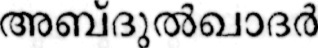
അബ്ദുല്‍ഖാദര്‍
